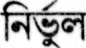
নির্ভুল
